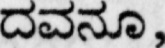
ದವನೂ,
